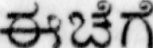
ಈಚೆಗೆ
